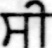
ਸੀ
